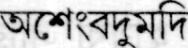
অশেংবদুমদি
